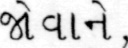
જોવાને,
